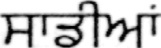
ਸਾਡੀਆਂ
